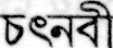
চৎনবী
